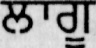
ਲਾਗੂ
